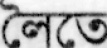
লৈতে
